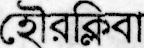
হৌরক্লিবা
